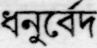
ধনুর্বেদ
